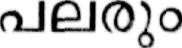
പലരും
